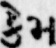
કેમ
